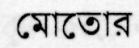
মোতোর
